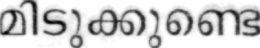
മിടുക്കുണ്ടെ
